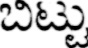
ಬಿಟ್ಟು
